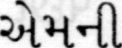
એમની
